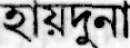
হায়দুনা
